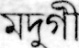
মদুগী
